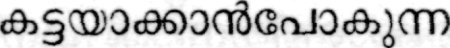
കട്ടയാക്കാന്‍പോകുന്ന
